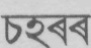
চহৰৰ
